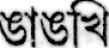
ঙাঙখি
